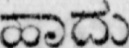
ಹಾದು
